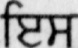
ਇਸ
